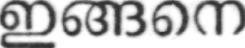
ഇങ്ങനെ
